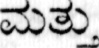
ಮತ್ತು
